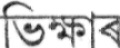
ভিক্ষাৰ
